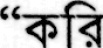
“করি
